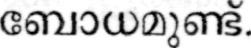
ബോധമുണ്ട്.
